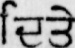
ਦਿਤੇ
